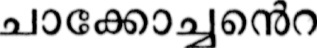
ചാക്കോച്ചന്റെ
